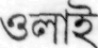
ওলাই
